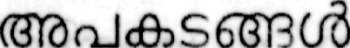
അപകടങ്ങള്‍
